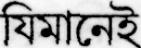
যিমানেই
